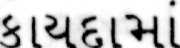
કાયદામાં
